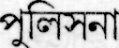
পুলিসনা
